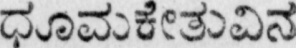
ಧೂಮಕೇತುವಿನ
